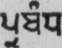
ਪ੍ਰਬੰਧ
